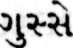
ગુસ્સે
